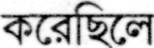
করেছিলে
